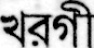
খরগী
